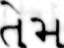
તેમ
